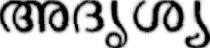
അദൃശ്യ
